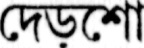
দেড়শো
